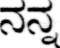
ನನ್ನ
